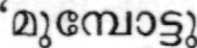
‘മുമ്പോട്ടു
